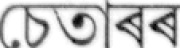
চেতাৰৰ
